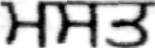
ਮਸਤ
